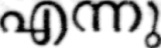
എന്നു
